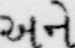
અને
